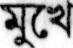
মুখে
